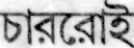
চাররোই
